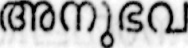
അനുഭവ
